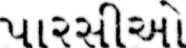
પારસીઓ
